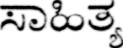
ಸಾಹಿತ್ಯ
